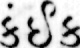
કંઇક
